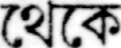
থেকে
